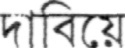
দাবিয়ে
